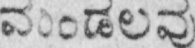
ಮಂಡಲವು
